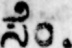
ಸೆಂ.
